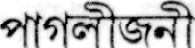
পাগলীজনী
